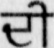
ਦੀ
